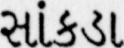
સાંકડા
